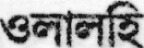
ওলালহি
